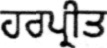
ਹਰਪ੍ਰੀਤ
